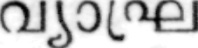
വ്യാഘ്ര
